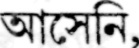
আসেনি,
